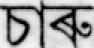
চাৰু
